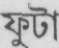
ফুটা
